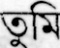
তুমি
